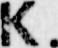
K.
